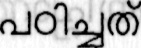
പഠിച്ചത്
